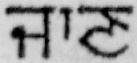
ਜਾਣ
